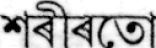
শৰীৰতো
